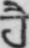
ਹੈ
